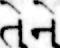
તેને
